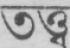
তত্ত্ব
